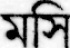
মসি
